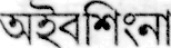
অইবশিংনা
